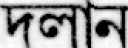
দলান
